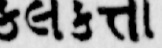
કલકત્તા
